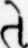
તે
